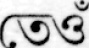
তেওঁ
